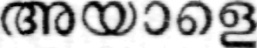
അയാളെ
